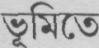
ভূমিতে
